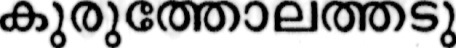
കുരുത്തോലത്തടു
